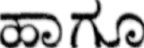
ಹಾಗೂ
